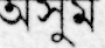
অসুম
